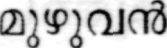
മുഴുവന്‍
